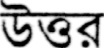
উত্তর
